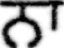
ਨਾ
